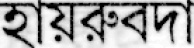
হায়রুবদা
